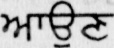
ਆਉਣ
